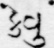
કેવું
